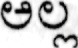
ಅಲ್ಲ
